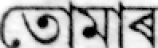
তোমাৰ
